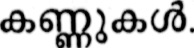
കണ്ണുകള്‍.
